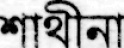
শাথীনা
